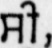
ਸੀ,
